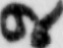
જ
